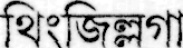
থিংজিল্লগা
